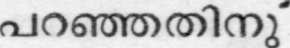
പറഞ്ഞതിനു
